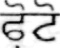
ਫ਼ੋਟੋ
